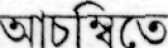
আচম্বিতে
